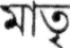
মাতৃ
